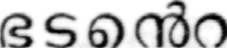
ഭടന്റെ
